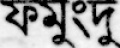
ফমুংদু
